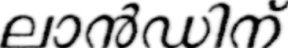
ലാന്‍ഡിന്
